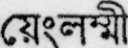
য়েংলম্মী
